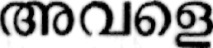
അവളെ
